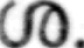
ശ.
